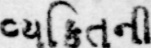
વ્યક્તિની
